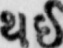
થઈ
